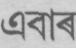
এবাৰ
